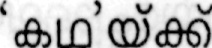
'കഥ'യ്ക്ക്
